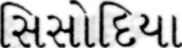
સિસોદિયા
